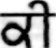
ਕੀ
